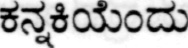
ಕನ್ನಕಿಯೆಂದು
